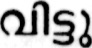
വിട്ടു
